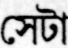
সেটা
